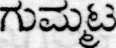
ಗುಮ್ಮಟ
